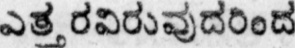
ಎತ್ತರವಿರುವುದರಿಂದ
